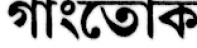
গাংতোক
